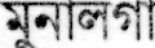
মুনালগা
